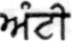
ਅੰਟੀ
